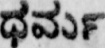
ಧರ್ಮ
